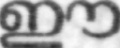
ഈ
